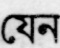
যেন
